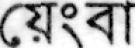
য়েংবা
